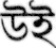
উই
